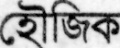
হৌজিক
